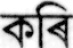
কৰি
